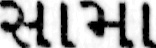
સામા
